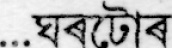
...ঘৰটোৰ
